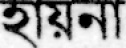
হায়না
